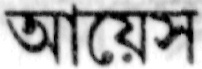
আয়েস
